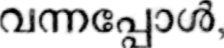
വന്നപ്പോള്‍,
